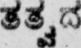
ತತ್ವದ
